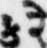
કરે
